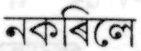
নকৰিলে
